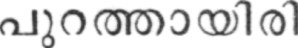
പുറത്തായിരി
